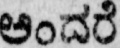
ಅಂದರೆ
